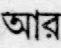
আর
